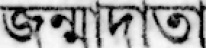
জন্মাদাতা
